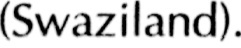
(Swaziland).
